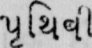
પૃથિવી
